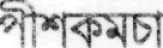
পীশকমচা
